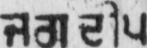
ਜਗਦੀਪ
